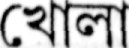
খোলা
